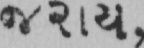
જરાય,
